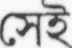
সেই
